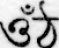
ওঁঠ
